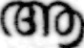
ആ
